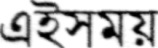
এইসময়
